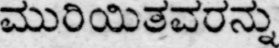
ಮುರಿಯಿತವರನ್ನು
